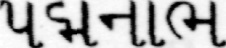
પદ્મનાભ
